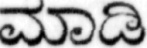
ಮಾಡಿ
